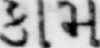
કામ
